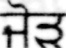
ਜੋੜ
